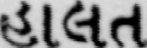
હાલત
